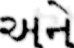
અને
